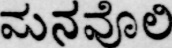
ಮನವೊಲಿ
